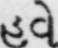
હવે
